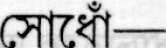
সোধোঁ-
